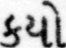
ક્યો
